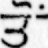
ਤੋਂ
